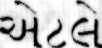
એટલે
